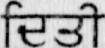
ਦਿਤੀ
